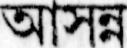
আসন্ন
